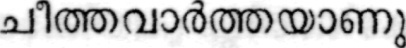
ചീത്തവാര്‍ത്തയാണു
